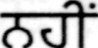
ਨਹੀਂ
